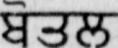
ਬੋਤਲ
